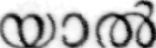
യാല്‍
